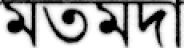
মতমদা
